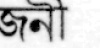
রজনী
